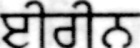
ਈਰੀਨ
